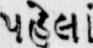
પહેલાં
